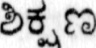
ಶಿಕ್ಷಣ
